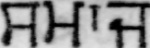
ਸਮਾਜ
